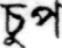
চুপ
